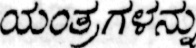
ಯಂತ್ರಗಳನ್ನು
